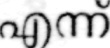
എന്ന്
